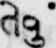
તેવું
